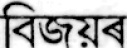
বিজয়ৰ
